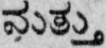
ಮತ್ತು
